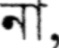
না,
